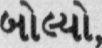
બોલ્યો,
